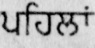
ਪਹਿਲਾਂ
